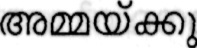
അമ്മയ്ക്കു
